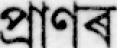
প্রাণৰ
